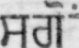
ਸਗੋਂ
